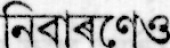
নিবাৰণেও
